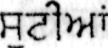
ਸੁਟੀਆਂ
